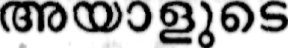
അയാളുടെ
